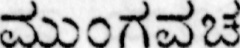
ಮುಂಗವಚ
